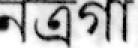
নত্রগা
